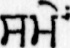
ਸਮੇਂ
